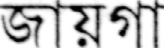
জায়গা
